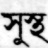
সুস্থ
